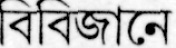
বিবিজানে
